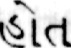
હોત
